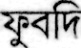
ফুবদি
